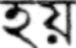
হয়
